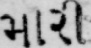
મારી
